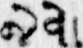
જેવો
